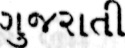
ગુજરાતી
